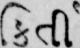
કિર્તી
